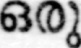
ഒരു
